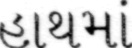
હાથમાં
